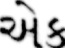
એક
